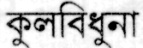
কুলবিধুনা
